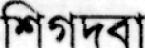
শিগদবা
